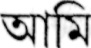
আমি
